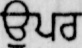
ਉਪਰ
